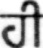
ਹੀ
